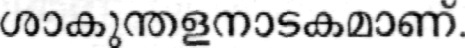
ശാകുന്തളനാടകമാണ്.
